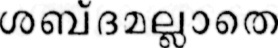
ശബ്ദമല്ലാതെ
